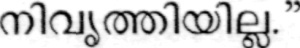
നിവൃത്തിയില്ല.”
